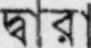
দ্বারা
